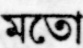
মতো
